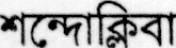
শন্দোক্লিবা
